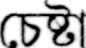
চেষ্টা
